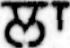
ਲਾ
